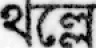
থল্লে
